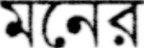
মনের
